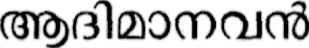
ആദിമാനവന്‍
